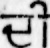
ਦੀ
